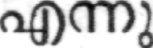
എന്നു
